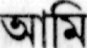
আমি
